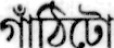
গাঁঠিটো
